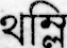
থম্লি
